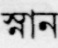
স্নান
